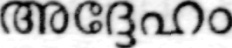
അദ്ദേഹം
